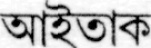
আইতাক
